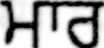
ਮਾਰ
